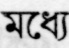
মধ্যে
